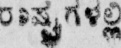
ರಾಷ್ಟ್ರಗಳಲ್ಲಿ
